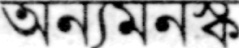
অন্যমনস্ক
